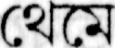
থেমে
